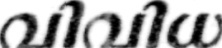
വിവിധ
